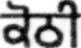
ਕੋਠੀ
